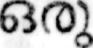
ഒരു
